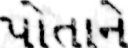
પોતાને
